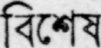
বিশেষ
